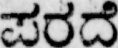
ಪರದೆ
